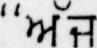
''ਅੱਜ
